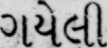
ગયેલી
